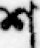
শ
